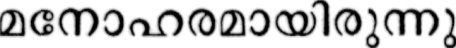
മനോഹരമായിരുന്നു
